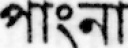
পাংনা
